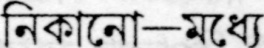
নিকানো—মধ্যে
